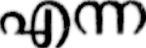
എന്ന
